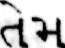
તેમ
